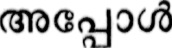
അപ്പോള്‍
